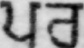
ਪਰ
